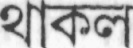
থাকল
